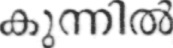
കുന്നില്‍
